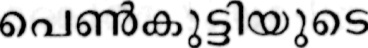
പെണ്‍കുട്ടിയുടെ
